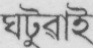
ঘটুৱাই
